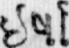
ઇર્ષા
